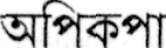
অপীকপা
